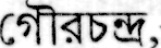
গৌরচন্দ্র,
